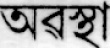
অৱস্হা
